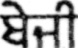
ਬੇਜੀ
